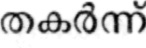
തകര്‍ന്ന്
